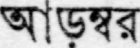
আড়ম্বর
